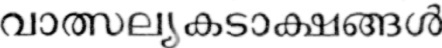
വാത്സല്യകടാക്ഷങ്ങള്‍
